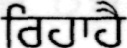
ਰਿਹਾਹੈ
